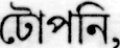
টোপনি,
